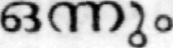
ഒന്നും
